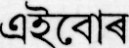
এইবোৰ
